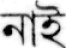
নাই
